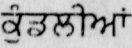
ਕੁੰਡਲੀਆਂ
